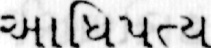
આધિપત્ય
